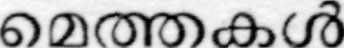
മെത്തകള്‍
